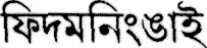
ফিদমনিংঙাই
